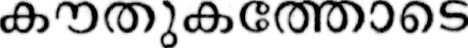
കൌതുകത്തോടെ
